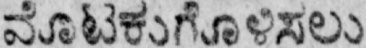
ಮೊಟಕುಗೊಳಿಸಲು
